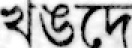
খঙদে
